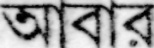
আবার
